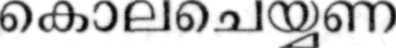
കൊലചെയ്യണ
